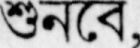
শুনবে,
